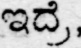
ಇದ್ರೆ,
